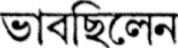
ভাবছিলেন
